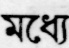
মধ্যে
